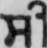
ਸੀ
